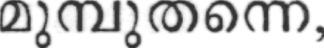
മുമ്പുതന്നെ,
